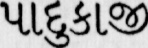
પાદુકાજી
